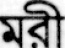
মরী
